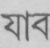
যাব
